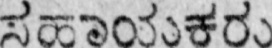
ಸಹಾಯಕರು
